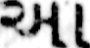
આ
